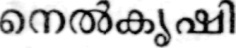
നെല്‍കൃഷി
